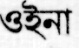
ওইনা
